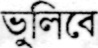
ভুলিবে
